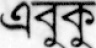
এবুকু
